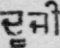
ਦੂਜੀ
